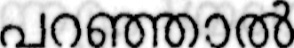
പറഞ്ഞാല്‍
